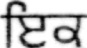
ਇਕ
